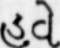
હવે
